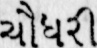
ચૌધરી
